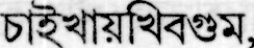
চাইখায়খিবগুম,
